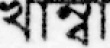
খাম্বা
